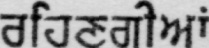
ਰਹਿਣਗੀਆਂ
